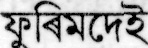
ফুৰিমদেই
